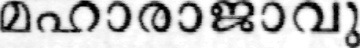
മഹാരാജാവു
